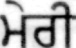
ਮੇਰੀ
